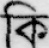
কি
